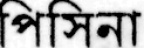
পিসিনা
